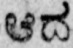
ಆದ
